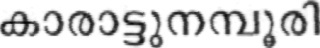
കാരാട്ടുനമ്പൂരി
